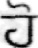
ਹੋ
